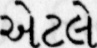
એટલે
